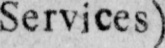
Services)
